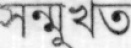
সন্মুখত
